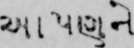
આપણને
